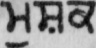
ਮੁਸ਼ਕ
